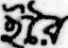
ইরৈ
